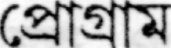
প্রোগ্রাম
